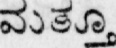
ಮತ್ತೂ
